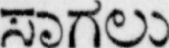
ಸಾಗಲು
